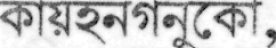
কায়হনগনুকো,
